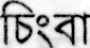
চিংবা
